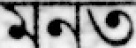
মনত
